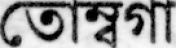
তোম্বগা
